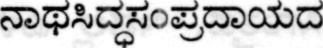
ನಾಥಸಿದ್ಧಸಂಪ್ರದಾಯದ
